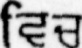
ਵਿਚ
